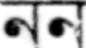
নন
